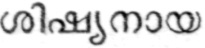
ശിഷ്യനായ
